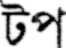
টপ
